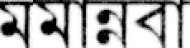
মমান্নবা
